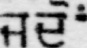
ਜਦੋਂ
